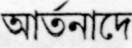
আর্তনাদে
